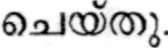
ചെയ്തു.
